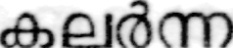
കലര്‍ന്ന
